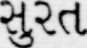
સુરત
